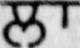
ਲਾ
